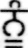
ਨੂੰ
